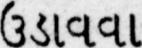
ઉડાવવા
